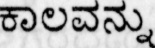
ಕಾಲವನ್ನು
